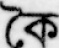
কৈ
